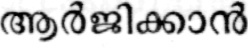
ആര്‍ജിക്കാന്‍
